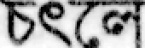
চৎলে
